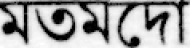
মতমদো
